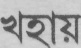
খহায়
